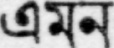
এমন
